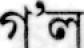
গ'ল
